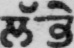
ਲੱਭੇ
